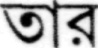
তার
